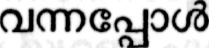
വന്നപ്പോള്‍
